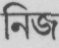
নিজ
